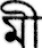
মী
